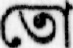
তো
